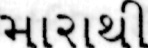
મારાથી
